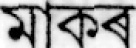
মাকৰ
